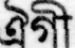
ঐগী
